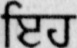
ਇਹ
